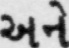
અને
